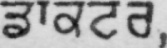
ਡਾਕਟਰ,
